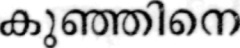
കുഞ്ഞിനെ
